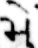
મેં
